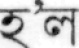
হ'ল
